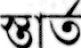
স্তার্ত
